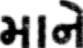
માને
